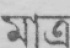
মাত্র
